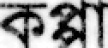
কপ্পা
